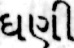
ઘણી
